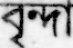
বৃন্দা
